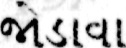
જોડાવા
